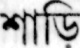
শাড়ি
